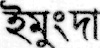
ইমুংদা
